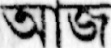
আজ
